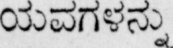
ಯವಗಳನ್ನು
